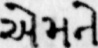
એમને
